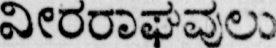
ವೀರರಾಘವುಲು
